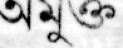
অমুক
